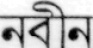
নবীন
